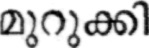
മുറുക്കി
